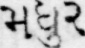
મધુર
